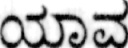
ಯಾವ
